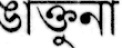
ঙাক্তুনা
